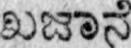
ಖಜಾನೆ
